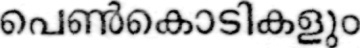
പെണ്‍കൊടികളും
